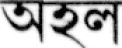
অহল
